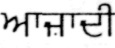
ਆਜ਼ਾਦੀ
